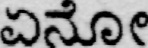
ಏನೋ
